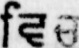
ਵਿਚ
